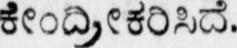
ಕೇಂದ್ರೀಕರಿಸಿದೆ.
